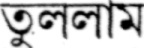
তুললাম
